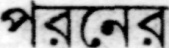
পরনের
